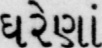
ઘરેણાં
